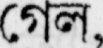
গেল,
